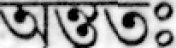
অন্ততঃ
